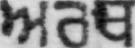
ਅਰਥ
